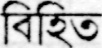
বিহিত
